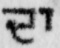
ਦਾ
